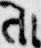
તો
